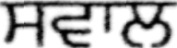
ਸਵਾਲ
